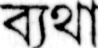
ব্যথা
